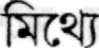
মিথ্যে
